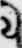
વિશેષ
